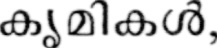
കൃമികള്‍,
